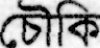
চৌকি
